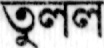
তুলল
